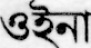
ওইনা
